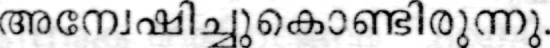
അന്വേഷിച്ചുകൊണ്ടിരുന്നു.
